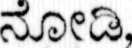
ನೋಡಿ,
